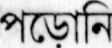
পড়োনি
